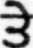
ਤੇ
